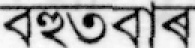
বহুতবাৰ
